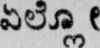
ಏಲ್ಲೋ
